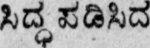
ಸಿದ್ಧಪಡಿಸಿದ
